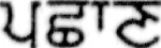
ਪਛਾਣ
